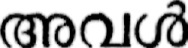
അവള്‍
